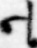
ન
